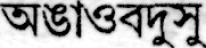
অঙাওবদুসু
